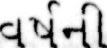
વર્ષની
